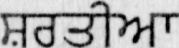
ਸ਼ਰਤੀਆ
